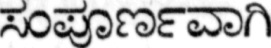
ಸಂಪೂರ್ಣವಾಗಿ
